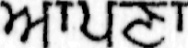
ਆਪਣਾ
